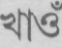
খাওঁ
